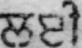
ਲਈ
